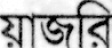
য়াজরি
